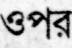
ওপর
